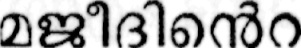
മജീദിന്റെ
